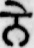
ਨੇ
